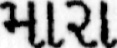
મારા
